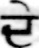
ਦੇ
